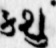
કશું
